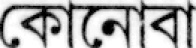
কোনোবা
